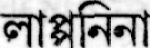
লাপ্পনিনা
